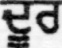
ਦੂਰ
